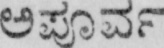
ಅಪೂರ್ವ
